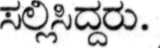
ಸಲ್ಲಿಸಿದ್ದರು.
